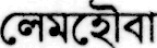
লেমহৌবা
